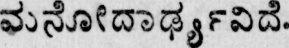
ಮನೋದಾರ್ಢ್ಯವಿದೆ.
